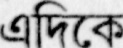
এদিকে
